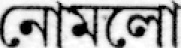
নোমলো
